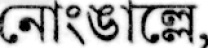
নোংঙাল্লে,
